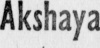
Akshaya
